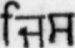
ਜਿਸ
